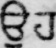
ਉਹ
